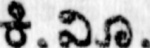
ಕಿ.ಮೀ.
